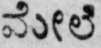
ಮೇಲೆ
